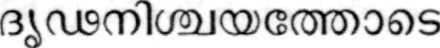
ദൃഢനിശ്ചയത്തോടെ
